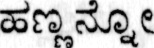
ಹಣ್ಣನ್ನೋ
